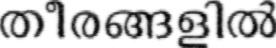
തീരങ്ങളില്‍
